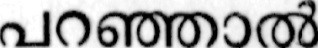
പറഞ്ഞാല്‍
